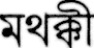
মথক্কী
